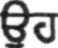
ਉਹ
